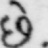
છે.
